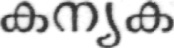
കന്യക
